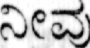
ನೀವು
